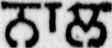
ਨਾਲ
